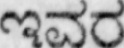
ಇವರ
